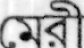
মেরী
